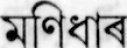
মণিধাৰ
